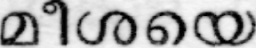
മീശയെ
